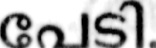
പേടി.
